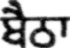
ਬੈਠਾ
